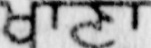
ਖਾਣਾ
